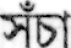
সঁচা
